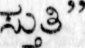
ಸ್ತುತಿ"
